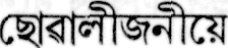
ছোৱালীজনীয়ে
